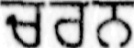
ਚਰਨ
